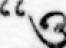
“ও
